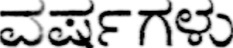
ವರ್ಷಗಳು
